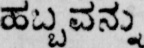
ಹಬ್ಬವನ್ನು
